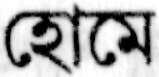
হোমে
